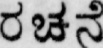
ರಚನೆ
